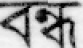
বন্ধ
